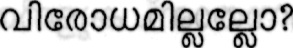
വിരോധമില്ലല്ലോ?
